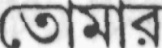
তোমার
